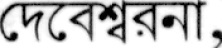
দেবেশ্বরনা,
